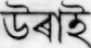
উৰাই
